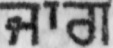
ਜਾਗ
